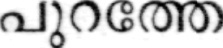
പുറത്തേ
